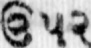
ઉપર
